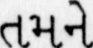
તમને
